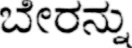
ಬೇರನ್ನು
